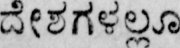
ದೇಶಗಳಲ್ಲೂ
